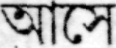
আসে
